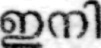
ഇനി
